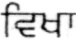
ਵਿਖਾ
